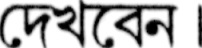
দেখবেন।
